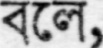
বলে,
